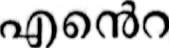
എന്റെ
